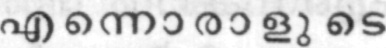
എന്നൊരാളുടെ
